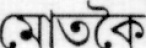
মোতকৈ
